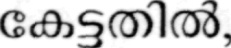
കേട്ടതില്‍,
